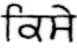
ਕਿਸੇ
